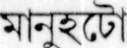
মানুহটো
